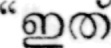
“ഇത്
